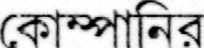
কোম্পানির
